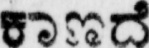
ಕಾಣದೆ
